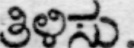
ತಿಳಿಸು.
